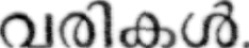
വരികള്‍.
